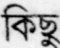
কিছু
